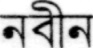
নবীন
